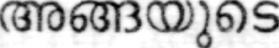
അങ്ങയുടെ
